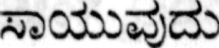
ಸಾಯುವುದು
